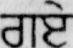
ਗਏ
